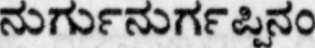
ನುರ್ಗುನುರ್ಗಪ್ಪಿನಂ
